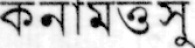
কনামত্তসু
